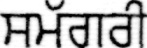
ਸਮੱਗਰੀ
